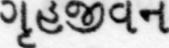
ગૃહજીવન
